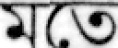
মতে
